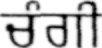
ਚੰਗੀ
